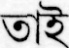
তাই
